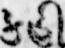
કહી
